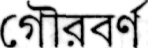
গৌরবর্ণ
